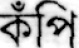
কঁপি
